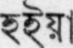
হইয়া
